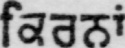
ਕਿਰਨਾਂ
